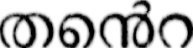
തന്റെ
